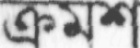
ক্রমশ
